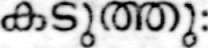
കടുത്തു:
